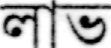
লাভ
